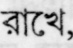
রাখে,
